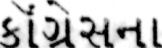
કૉંગ્રેસના
